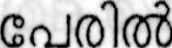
പേരില്‍
